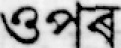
ওপৰ
